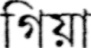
গিয়া
